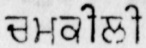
ਚਮਕੀਲੀ
